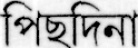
পিছদিনা
